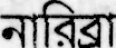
নারিব্রা
